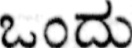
ಒಂದು
